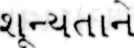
શૂન્યતાને
